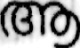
ആ
